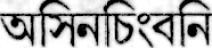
অসিনচিংবনি
